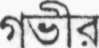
গভীর
